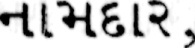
નામદાર,
